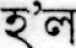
হ'ল
